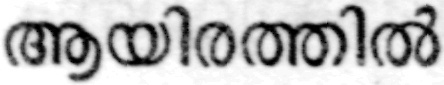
ആയിരത്തില്‍
